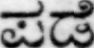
ಪಡೆ
